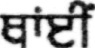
ਥਾਂਈਂ
